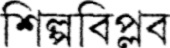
শিল্পবিপ্লব,
